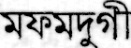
মফমদুগী
